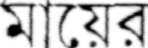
মায়ের
